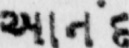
આનંદ
